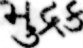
મુદ્રક
